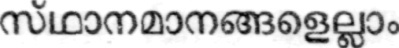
സ്ഥാനമാനങ്ങളെല്ലാം
